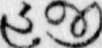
હજી
